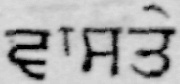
ਵਾਸਤੇ
